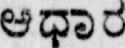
ಆಧಾರ
